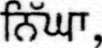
ਨਿੱਘਾ,
